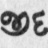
જીદ
